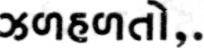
ઝળહળતો,
